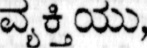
ವ್ಯಕ್ತಿಯು,
